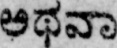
ಅಥವಾ
